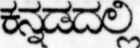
ಕನ್ನಡದಲ್ಲಿ
